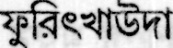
ফুরিৎখাউদা
